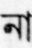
না
